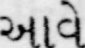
આવે
